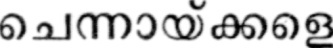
ചെന്നായ്ക്കളെ
